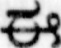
ಈ
